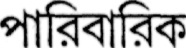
পারিবারিক
